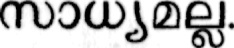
സാധ്യമല്ല.
